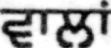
ਵਾਲਾਂ
